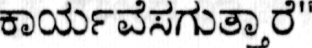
ಕಾರ್ಯವೆಸಗುತ್ತಾರೆ”
